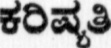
ಕರಿಷ್ಯತಿ
